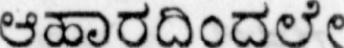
ಆಹಾರದಿಂದಲೇ
